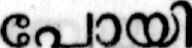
പോയി
